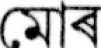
মোৰ
